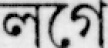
লগে
